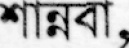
শান্নবা,
